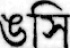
ঙসি
